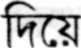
দিয়ে
